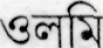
ওলমি
